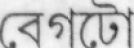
বেগটো
